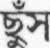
ছুঁস
